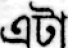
এটা
